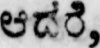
ಆದರೆ,
